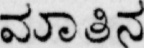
ಮಾತಿನ
